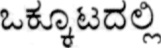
ಒಕ್ಕೂಟದಲ್ಲಿ
